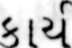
કાર્ય
